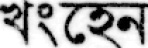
খংহেন
